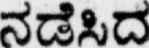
ನಡೆಸಿದ
